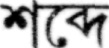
শব্দে
